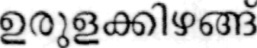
ഉരുളക്കിഴങ്ങ്
